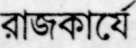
রাজকার্যে
